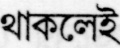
থাকলেই
